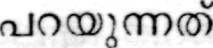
പറയുന്നത്
